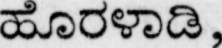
ಹೊರಳಾಡಿ,
